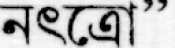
নৎত্রো”
